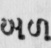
બળ
